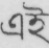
এই
